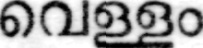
വെള്ളം
